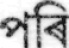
পৰি
